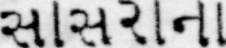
સાસરના
